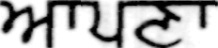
ਆਪਣਾ
